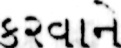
કરવાને
